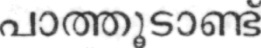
പാത്തൂടാണ്ട്
